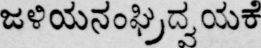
ಜಳಿಯನಂಘ್ರಿದ್ವಯಕೆ
